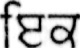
ਇਕ
